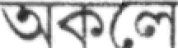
অকলে
